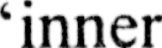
'inner
